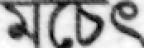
মচেৎ
